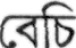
বেচি
